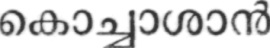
കൊച്ചാശാന്‍
